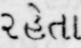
રહેતા
